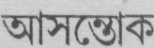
আসন্তোক
